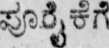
ಪೂರೈಕೆಗೆ
